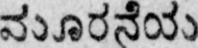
ಮೂರನೆಯ
